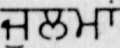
ਜੁਲਮਾਂ
